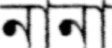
নানা
